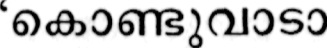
‘കൊണ്ടുവാടാ
